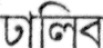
ঢালিব
